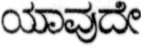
ಯಾವುದೇ
